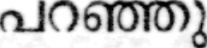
പറഞ്ഞു
